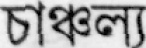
চাঞ্চল্য
